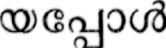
യപ്പോള്‍
